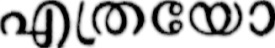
എത്രയോ
